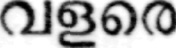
വളരെ
